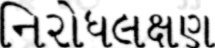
નિરોધલક્ષણ
